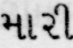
મારી
